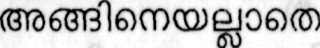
അങ്ങിനെയല്ലാതെ
